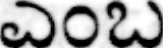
ಎಂಬ
